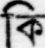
কি
